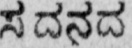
ಸದನದ
